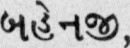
બહેનજી,
